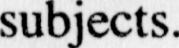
subjects.
